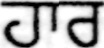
ਹਾਰ
